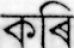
কৰি
